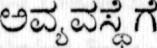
ಅವ್ಯವಸ್ಥೆಗೆ
